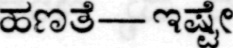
ಹಣತೆ-ಇಷ್ಟೇ
